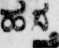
ಹಸ್ತ
